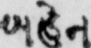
બહેન
